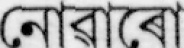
নোৱাৰো
